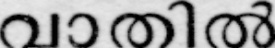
വാതില്‍
